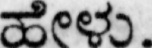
ಹೇಳು.
